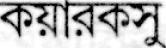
কয়ারকসু
